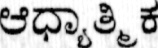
ಆಧ್ಯಾತ್ಮಿಕ
